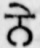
ਨੇ
